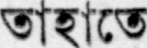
তাহাতে
